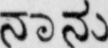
ನಾನು
